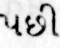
પછી
